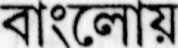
বাংলোয়
